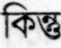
কিন্তু
